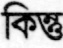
কিন্তু
